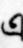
এ
